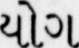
યોગ
